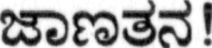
ಜಾಣತನ!
